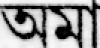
অমা
